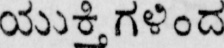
ಯುಕ್ತಿಗಳಿಂದ
